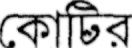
কোটির
